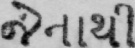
જનાથી
